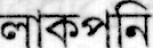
লাকপনি
